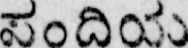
ಪಂದಿಯ
